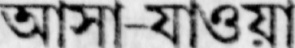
আসা-যাওয়া
